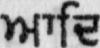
ਆਦਿ
